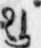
શું
